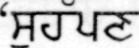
'ਸੁਹੱਪਣ
